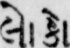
લોકો
